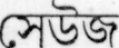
সেউজ
